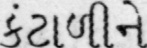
કંટાળીને
